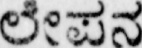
ಲೇಪನ
